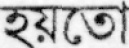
হয়তো
